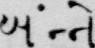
બંન્ને
